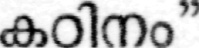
കഠിനം"
